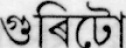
গুৰিটো
